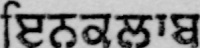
ਇਨਕਲਾਬ
